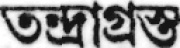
তন্দ্রাগ্রস্ত
